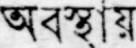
অবস্থায়
